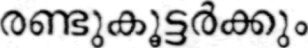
രണ്ടുകൂട്ടര്‍ക്കും
